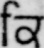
ਕਿ
